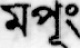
মপূং
